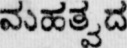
ಮಹತ್ವದ
